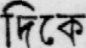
দিকে
